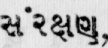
સંરક્ષણ,
